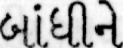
બાંધીને
